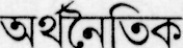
অৰ্থনৈতিক
